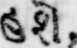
હશે,
